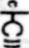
ਨੂੰ
